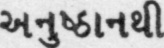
અનુષ્ઠાનથી
